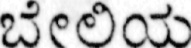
ಬೇಲಿಯ
